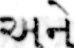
અને
